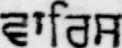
ਵਾਰਿਸ
